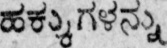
ಹಕ್ಕುಗಳನ್ನು
